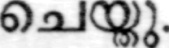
ചെയ്തു.
